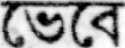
ভেবে
